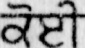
ਕੋਈ
